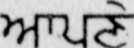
ਆਪਣੇ
